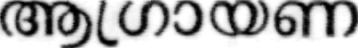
ആഗ്രായണ
